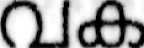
വക
